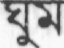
ঘুম
